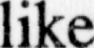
like
